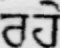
ਰਹੇ
